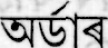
অর্ডাৰ
